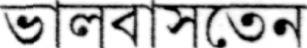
ভালবাসতেন
